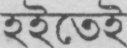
হইতেই
